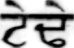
ਟੇਢੇ
